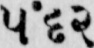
પંદર
